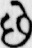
છે
